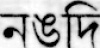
নঙদি
